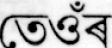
তেওঁৰ
